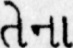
તેના
